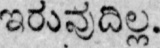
ಇರುವುದಿಲ್ಲ.
